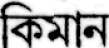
কিমান
